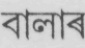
বালাৰ
